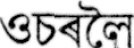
ওচৰলৈ
